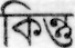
কিন্তু
